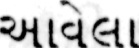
આવેલા
